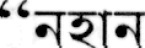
“নহান
